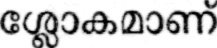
ശ്ലോകമാണ്
